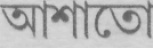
আশাতো
